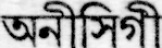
অনীসিগী
